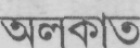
অলকাত
